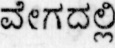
ವೇಗದಲ್ಲಿ
